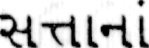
સત્તાનાં
